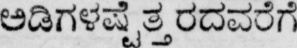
ಅಡಿಗಳಷ್ಟೆತ್ತರದವರೆಗೆ
